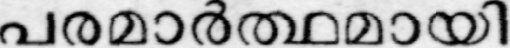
പരമാര്‍ത്ഥമായി
